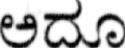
ಅದೂ
